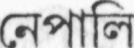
নেপালি
